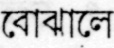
বোঝালে
